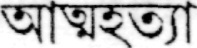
আত্মহত্যা
